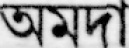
অমদা
